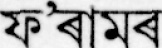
ফ'ৰামৰ
